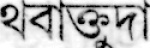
থবাক্তুদা
